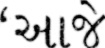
'આજે
